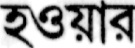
হওয়ার
